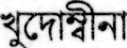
খুদোম্বীনা
